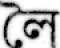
লৈ
